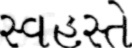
સ્વહસ્તે
